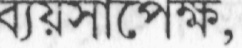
ব্যয়সাপেক্ষ,
